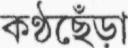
কণ্ঠছেঁড়া
